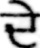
ਦੇ
